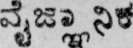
ವೈಜ್ಞಾನಿಕ
